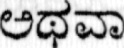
ಅಥವಾ
